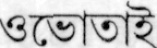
ওভোতাই
